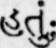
હતું;
